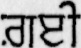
ਗਈ
